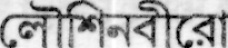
লৌশিনবীরো
